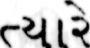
ત્યારે
